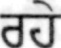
ਰਹੇ
